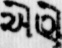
એણે
